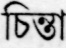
চিন্তা
